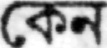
কেন
